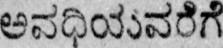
ಅವಧಿಯವರೆಗೆ
